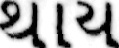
થાય
